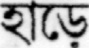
হাড়ে
